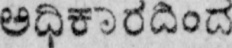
ಅಧಿಕಾರದಿಂದ
